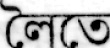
লৈতে
